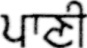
ਪਾਣੀ
